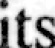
its
